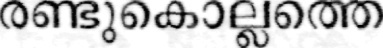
രണ്ടുകൊല്ലത്തെ
